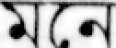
মনে
